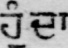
ਹੁੰਦਾ
